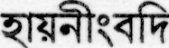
হায়নীংবদি
